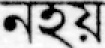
নহয়
